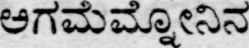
ಅಗಮೆಮ್ನೋನಿನ
